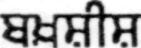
ਬਖ਼ਸ਼ੀਸ਼
